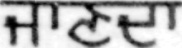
ਜਾਣਦਾ
